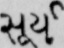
સૂર્ય
